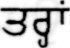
ਤਰ੍ਹਾਂ
